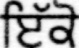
ਇੱਕੋ
